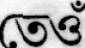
তেওঁ
